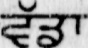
ਵੱਡਾ
